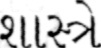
શાસ્ત્રે
